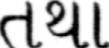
તથા
